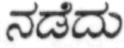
ನಡೆದು
